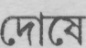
দোষে
